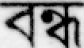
বন্ধ
